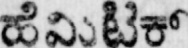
ಹೆಮಿಟಿಕ್
